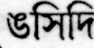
ঙসিদি
